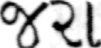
જરા
